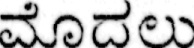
ಮೊದಲು
